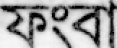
ফংবা
